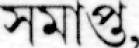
সমাপ্ত,
